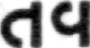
તવ
